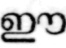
ഈ
